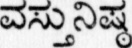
ವಸ್ತುನಿಷ್ಠ
